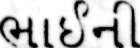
ભાઈની
